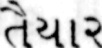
તૈયાર
